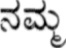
ನಮ್ಮ
